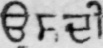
ਉਸਦੀ
